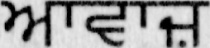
ਆਵਾਜ਼
